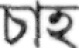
চাহ
